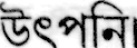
উৎপনি।
